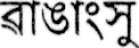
ৱাঙাংসু
